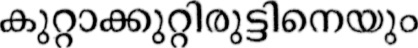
കുറ്റാക്കുറ്റിരുട്ടിനെയും
